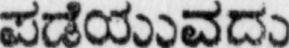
ಪಡೆಯುವುದು
